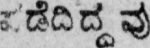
ಪಡೆದಿದ್ದವು
